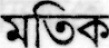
মতিক
